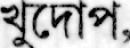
খুদোপ,
